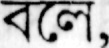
বলে,
